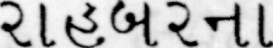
રાહબરના
